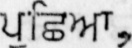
ਪੁਛਿਆ,
